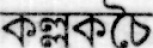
কল্লকচৈ
